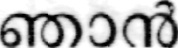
ഞാന്‍
